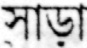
সাড়া
